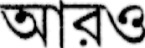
আরও
